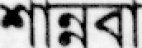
শান্নবা
